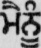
ਮੈਨੂੰ
